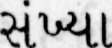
સંખ્યા
